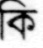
কি
